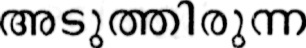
അടുത്തിരുന്ന
